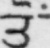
ਤੋਂ
